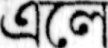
এলে
